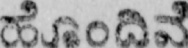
ಹೊಂದಿವೆ
